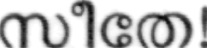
സീതേ!
